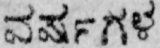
ವರ್ಷಗಳ
